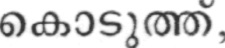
കൊടുത്ത്,
